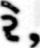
રે,
